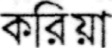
করিয়া
